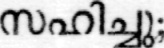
സഹിച്ചു;
